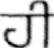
ਹੀ
